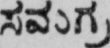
ಸಮಗ್ರ
